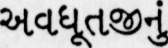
અવધૂતજીનું
